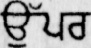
ਉੱਪਰ
